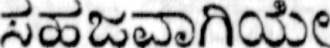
ಸಹಜವಾಗಿಯೇ
